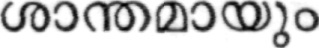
ശാന്തമായും
